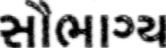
સૌભાગ્ય
